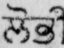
ਲੋਭੀ
